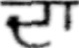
ਦਾ
